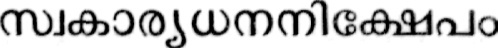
സ്വകാര്യധനനിക്ഷേപം
